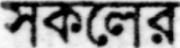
সকলের
